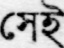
সেই
